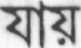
যায়
